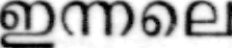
ഇന്നലെ
